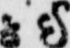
કંઈ
